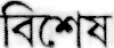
বিশেষ
